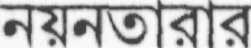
নয়নতারার
